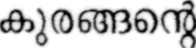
കുരങ്ങന്റെ
